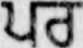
ਪਰ
